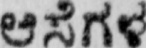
ಆಸೆಗಳ
